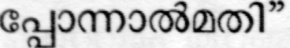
പ്പോന്നാല്‍മതി”
